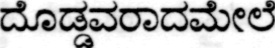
ದೊಡ್ಡವರಾದಮೇಲೆ
